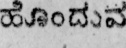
ಹೊಂದುವ
